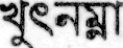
খুৎনম্না
